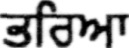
ਭਰਿਆ
